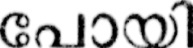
പോയി
